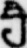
ਹੈ
